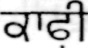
ਕਾਫ਼ੀ
